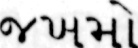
જખમો
